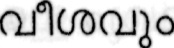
വീശവും
